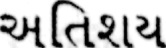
અતિશય
